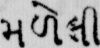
મળેલી
